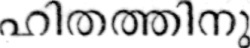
ഹിതത്തിനു
